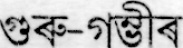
গুৰু-গম্ভীৰ
